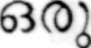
ഒരു
